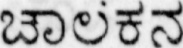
ಚಾಲಕನ
